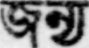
জন্য
